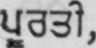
ਪੂਰਤੀ,
